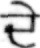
ਦੇ
